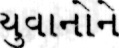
યુવાનોને
